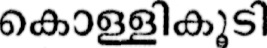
കൊള്ളികൂടി
